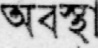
অবস্থা
